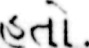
હતો.
